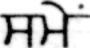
ਸਮੇਂ
